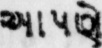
આપણે
